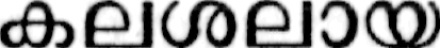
കലശലായ
